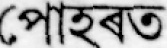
পোহৰত
